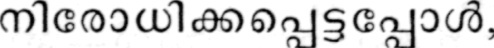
നിരോധിക്കപ്പെട്ടപ്പോള്‍,
